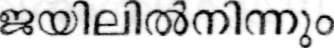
ജയിലില്‍നിന്നും
